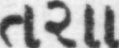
તરા।
